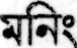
মনিং
